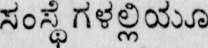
ಸಂಸ್ಥೆಗಳಲ್ಲಿಯೂ
